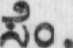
ಸೆಂ.
